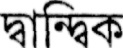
দ্বান্দ্বিক
